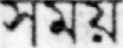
সময়
